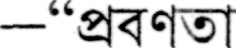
–“প্রবণতা
